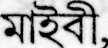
মাইবী,
